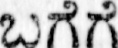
ಬಗೆಗೆ
